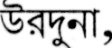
উরদুনা,
